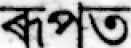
ৰূপত
